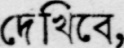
দেখিবে,
